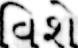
વિશે
